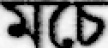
মচে
